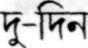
দু-দিন
